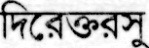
দিরেক্তরসু
